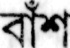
বাঁশ
